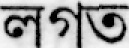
লগত
